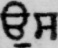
ਉਸ
